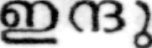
ഇന്ദു
